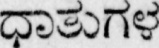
ಧಾತುಗಳ
